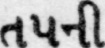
તપની
